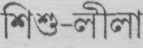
শিশু-লীলা
